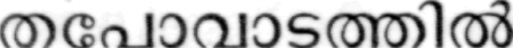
തപോവാടത്തില്‍
